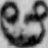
ಆ
